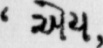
'એય,
